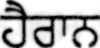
ਹੈਰਾਨ
